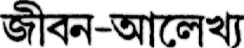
জীবন-আলেখ্য
